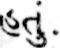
હતું.
